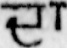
ਦਾ
